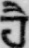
ਹੈ
